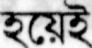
হয়েই
